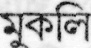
মুকলি
